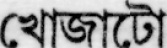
খোজাটো
